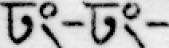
ঢং-ঢং-
